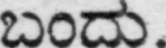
ಬಂದು.
